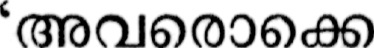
‘അവരൊക്കെ
